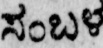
ಸಂಬಳ
